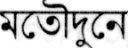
মতৌদুনে
